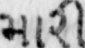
મારી
